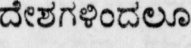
ದೇಶಗಳಿಂದಲೂ
